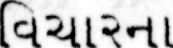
વિચારના
